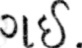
ગઈ.
